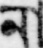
না
